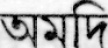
অমদি
